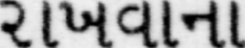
રાખવાના
